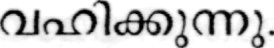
വഹിക്കുന്നു.
